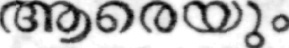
ആരെയും
